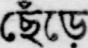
ছেঁড়ে
